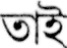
তাই
